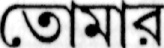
তোমার
